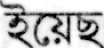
ইয়েছ
